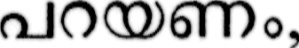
പറയണം,
